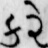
કરે
